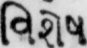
વિશેષ
